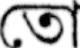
তো
